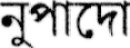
নুপাদো
